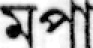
মপা
